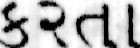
કરતા
